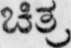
ಚಿತ್ರ
